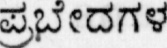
ಪ್ರಬೇದಗಳ
